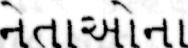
નેતાઓના
